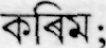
কৰিম;
